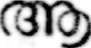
ആ
